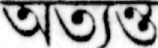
অত্যন্ত
